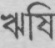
ঋষি
